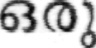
ഒരു
